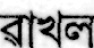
ৱাখল
